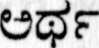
ಅರ್ಥ
